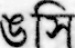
ঙসি
